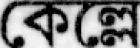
কেল্লে
